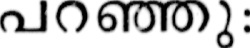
പറഞ്ഞു:
